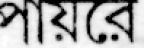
পায়রে
